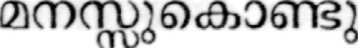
മനസ്സുകൊണ്ടു
